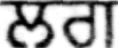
ਲਗ
